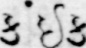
કંઈક
